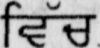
ਵਿੱਚ
